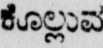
ಕೊಲ್ಲುವ
